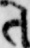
તે
